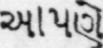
આપણે
